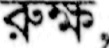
রুক্ষ,
